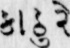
કાઠુરે
